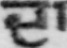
ਦਾ
